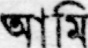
আমি
